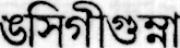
ঙসিগীগুম্না
